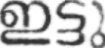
ഇട്ടു
